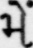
મેં
